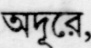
অদূরে,
